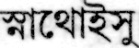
স্নাথোইসু
